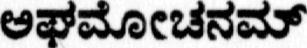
ಅಘಮೋಚನಮ್
